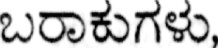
ಬರಾಕುಗಳು,
